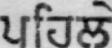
ਪਹਿਲੇ
